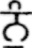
ਨੂੰ
